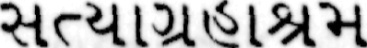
સત્યાગ્રહાશ્રમ
